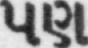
પણ
